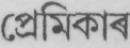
প্ৰেমিকাৰ
